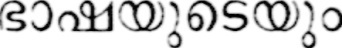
ഭാഷയുടെയും
